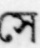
সে
